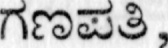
ಗಣಪತಿ,
